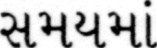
સમયમાં
